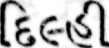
દિલ્હી
